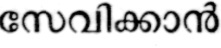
സേവിക്കാന്‍
